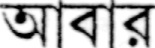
আবার
